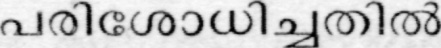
പരിശോധിച്ചതില്‍
